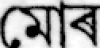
মোৰ
